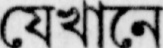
যেখানে
